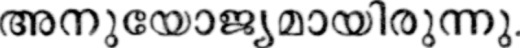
അനുയോജ്യമായിരുന്നു.
